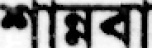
শান্নবা
